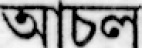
আচল
